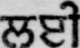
ਲਈ
